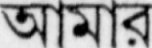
আমার
